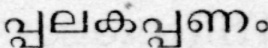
പ്പലകപ്പണം
